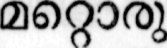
മറ്റൊരു
